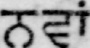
ਨਵਾਂ
